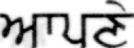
ਆਪਣੇ
